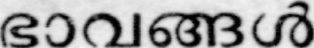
ഭാവങ്ങള്‍
